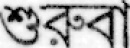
শুরুবা
